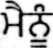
ਮੈਨੂੰ
